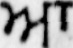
ਆ
